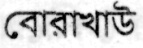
বোরাখাউ
